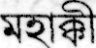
মহাক্কী
